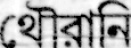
থৌরানি
